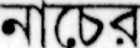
নাচের
